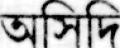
অসিদি
